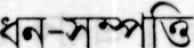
ধন-সম্পত্তি
